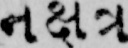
નક્ષત્ર
